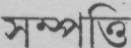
সম্পত্তি
